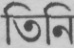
তিনি
